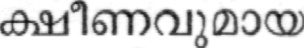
ക്ഷീണവുമായ
